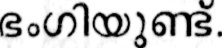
ഭംഗിയുണ്ട്.
